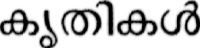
കൃതികള്‍
